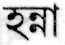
হন্না
